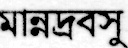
মান্নদ্রবসু
